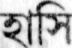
হাসি
